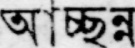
আচ্ছন্ন
